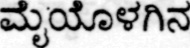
ಮೈಯೊಳಗಿನ
